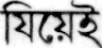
যিয়েই
